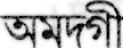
অমদগী
